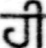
ਹੀ
